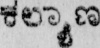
ಕಲ್ಯಾಣ
